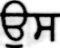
ਉਸ
